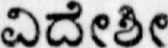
ವಿದೇಶೀ
